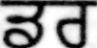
ਡਰ
